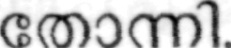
തോന്നി.
